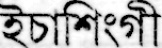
ইচাশিংগী
